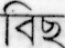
বিছ
